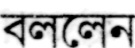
বললেন
